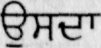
ਉਸਦਾ
